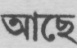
আছে
